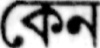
কেন
